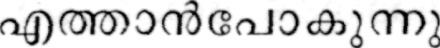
എത്താന്‍പോകുന്നു
